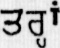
ਤਰ੍ਹਾਂ
